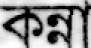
কন্না
